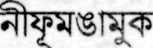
নীফূমঙামুক
